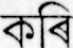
কৰি
